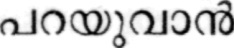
പറയുവാന്‍
